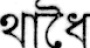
থাধৈ
